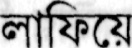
লাফিয়ে
